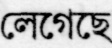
লেগেছে
